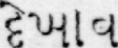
દેખાવ
